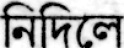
নিদিলে
